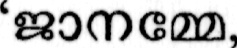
‘ജാനമ്മേ,
